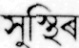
সুস্থিৰ
